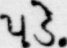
પડે.
